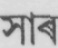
সাৰ
